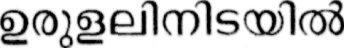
ഉരുളലിനിടയില്‍
